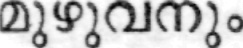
മുഴുവനും
